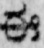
ಈ
